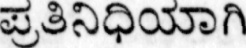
ಪ್ರತಿನಿಧಿಯಾಗಿ
